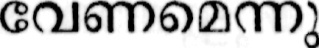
വേണമെന്നു
